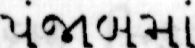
પંજાબમાં
